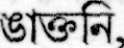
ঙাক্তনি,
